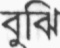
বুঝি
